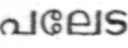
പലേട
